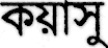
কয়াসু
